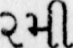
રમી
